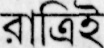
রাত্রিই
